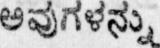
ಅವುಗಳನ್ನು
